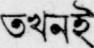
তখনই
